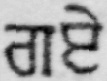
ਗਏ
